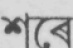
শৰে
